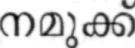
നമുക്ക്
